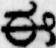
ಈ
